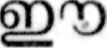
ഈ
